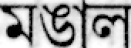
মঙাল
